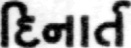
દિનાર્ત
